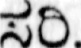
ಸರಿ.
